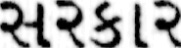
સરકાર
